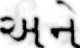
અને
